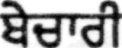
ਬੇਚਾਰੀ
